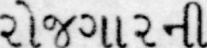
રોજગારની
